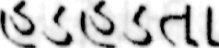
હડહડતા
